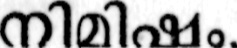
നിമിഷം.
